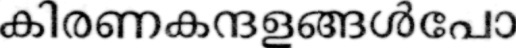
കിരണകന്ദളങ്ങള്‍പോ
